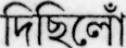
দিছিলোঁ
